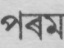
পৰম
